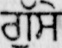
ਗੁੱਸੇ
